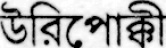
উরিপোক্কী
